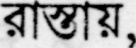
রাস্তায়,
